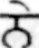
ਨੇ
